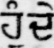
ਹੁੰਦੇ
